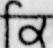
ਕਿ
